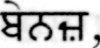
ਬੇਨਜ਼,
